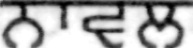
ਨਾਵਲ
